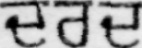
ਦਰਦ
